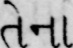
તેના
